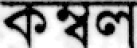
কম্বল
